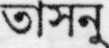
তাসনু
